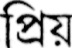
প্রিয়
